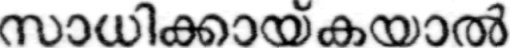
സാധിക്കായ്കയാല്‍
